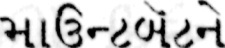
માઉન્ટબૅટને
